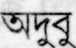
অদুবু
